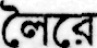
লৈরে
